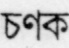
চণক
